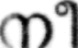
നീ
